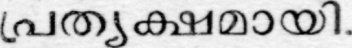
പ്രത്യക്ഷമായി.
